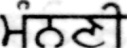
ਮੰਨਣੀ
